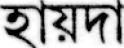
হায়দা
